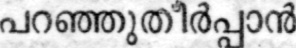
പറഞ്ഞുതീര്‍പ്പാന്‍
